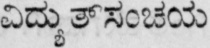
ವಿದ್ಯುತ್‌ಸಂಚಯ
